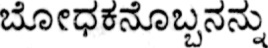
ಬೋಧಕನೊಬ್ಬನನ್ನು
